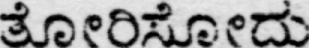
ತೋರಿಸೋದು
